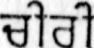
ਚੀਰੀ
